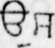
ਉਸ
